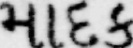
માદક
